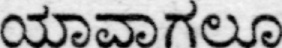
ಯಾವಾಗಲೂ
